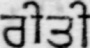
ਰੀਤੀ
